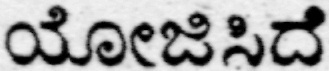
ಕಾಮೂಂದ
